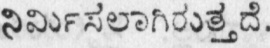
ನಿರ್ಮಿಸಲಾಗಿರುತ್ತದೆ.
